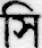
সি
